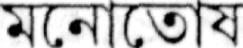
মনোতোষ
